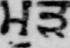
ਮੁੜ
